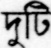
দুটি
